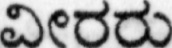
ವೀರರು
